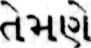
તેમણે
